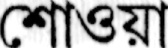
শোওয়া
